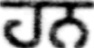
ਹਨ
